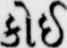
કોઈ
